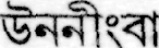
উননীংবা
